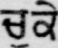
ਚੁਕੇ
